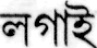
লগাই
